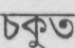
চকুত
